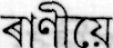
ৰাণীয়ে
